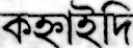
কহ্নাইদি
